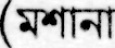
(মশানা
